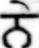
ਨੇ
